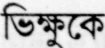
ভিক্ষুকে
